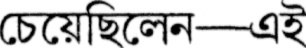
চেয়েছিলেন-এই
